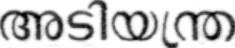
അടിയന്ത്ര
